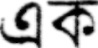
এক
